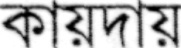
কায়দায়
